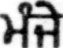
ਮੰਜੇ
